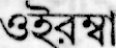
ওইরম্বা
